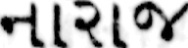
નારાજ
